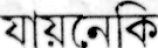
যায়নেকি
